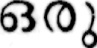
ഒരു
